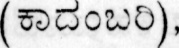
(ಕಾದಂಬರಿ),
